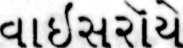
વાઈસરૉયે
